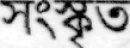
সংস্কৃত
